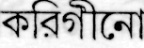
করিগীনো
